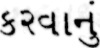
કરવાનું
